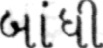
બાંધી
